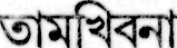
তামখিবনা
